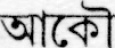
আকৌ
